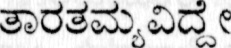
ತಾರತಮ್ಯವಿದ್ದೇ
